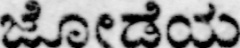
ಜೋಡೆಯ
